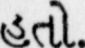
હતો.
